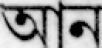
আন
